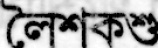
লৈশকশু
